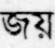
জয়
